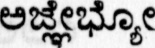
ಅಜ್ಞೇಭ್ಯೋ
